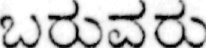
ಬರುವರು
